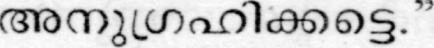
അനുഗ്രഹിക്കട്ടെ."
